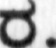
ರ.
